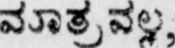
ಮಾತ್ರವಲ್ಲ,
